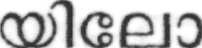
യിലോ
